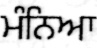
ਮੰਨਿਆ
